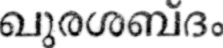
ഖുരശബ്ദം
